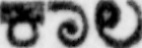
ಕಾಲ
